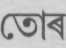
তোৰ
